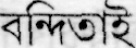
বন্দিতাই
